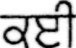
ਕਈ
